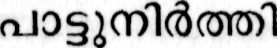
പാട്ടുനിര്‍ത്തി
